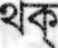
থক্
